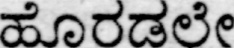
ಹೊರಡಲೇ
